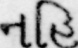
નહિ
